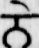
ਨੇ
